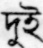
দুই
